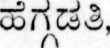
ಹೆಗ್ಗಡತಿ,
